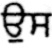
ਉਸ
